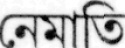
নেমাতি
